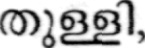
തുള്ളി,
